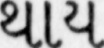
થાય
